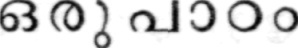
ഒരുപാഠം
